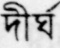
দীর্ঘ
